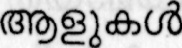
ആളുകള്‍
